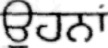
ਉਹਨਾਂ
